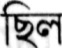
ছিল
